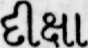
દીક્ષા
